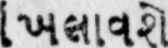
ખિલાવશે
